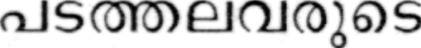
പടത്തലവരുടെ
